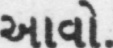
આવો.
